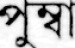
পুম্বা
